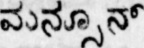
ಮನ್ಸೂನ್
